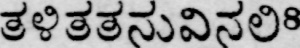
ತಳಿತತನುವಿನಲಿ8
